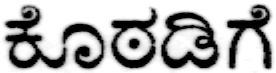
ಕೊಠಡಿಗೆ
